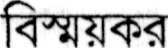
বিস্ময়কর
